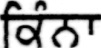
ਕਿੰਨਾ
